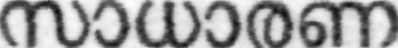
സാധാരണ
